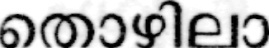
തൊഴിലാ
